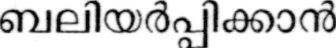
ബലിയര്‍പ്പിക്കാന്‍
